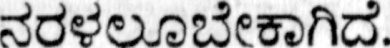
ನರಳಲೂಬೇಕಾಗಿದೆ.
